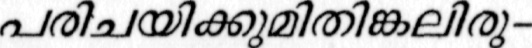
പരിചയിക്കുമിതിങ്കലിരു-
